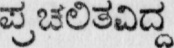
ಪ್ರಚಲಿತವಿದ್ದ
